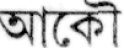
আকৌ
